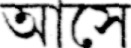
আসে
